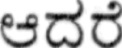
ಆದರೆ
